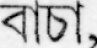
বাচা,
